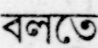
বলতে
